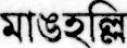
মাঙহল্লি
